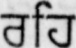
ਰਹਿ
